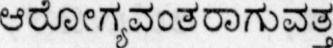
ಆರೋಗ್ಯವಂತರಾಗುವತ್ತ
